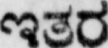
ಇತರ
